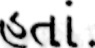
હતાં.
